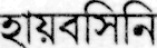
হায়বসিনি
